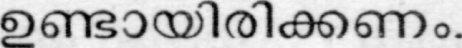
ഉണ്ടായിരിക്കണം.
